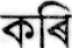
কৰি
